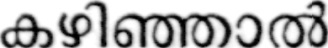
കഴിഞ്ഞാല്‍
